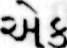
એક
